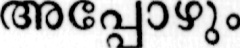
അപ്പോഴും
